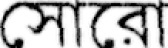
সোরো
